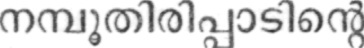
നമ്പൂതിരിപ്പാടിന്റെ
